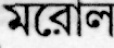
মরোল
